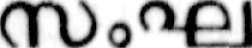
സംഘ
